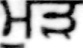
ਮੁੜ
